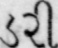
ડરી
